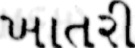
ખાતરી
